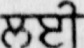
ਲਈ
